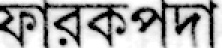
ফারকপা
